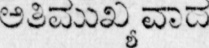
ಅತಿಮುಖ್ಯವಾದ
